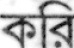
করি
